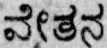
ವೇತನ
